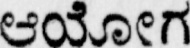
ಆಯೋಗ
